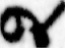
જે
